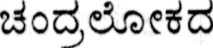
ಚಂದ್ರಲೋಕದ
